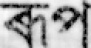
ৰূপ
